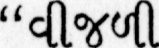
"વીજળી
